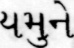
યમુને
